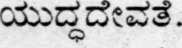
ಯುದ್ಧದೇವತೆ.
